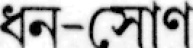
ধন-সোণ
